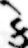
કે
